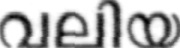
വലിയ
